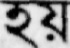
হয়
